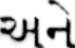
અને
